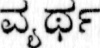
ವ್ಯರ್ಥ
